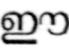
ഈ
